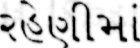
રહેણીમાં
